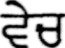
ਵੇਚ
